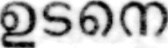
ഉടനെ
